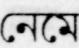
নেমে
